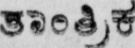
ತಾಂತ್ರಿಕ
